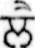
ਲੈ
